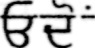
ਓਦੋਂ
